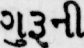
ગુરૂની
